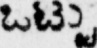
ಒಟ್ಟು
